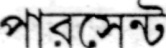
পারসেন্ট
